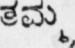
ತಮ್ಮ
